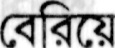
বেরিয়ে
